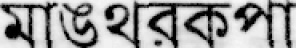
মাঙথরকপা
